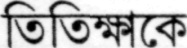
তিতিক্ষাকে
